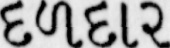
દળદાર
